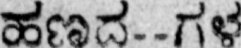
ಹಣದ--ಗಳ
